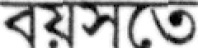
বয়সতে
